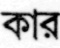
কার
